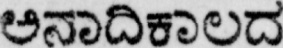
ಅನಾದಿಕಾಲದ
